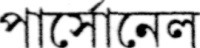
পার্সোনেল
